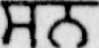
ਸਨ
